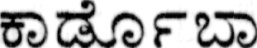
ಕಾರ್ಡೊಬಾ
